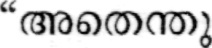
“അതെന്തു
